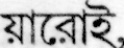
য়ারোই,
